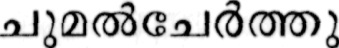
ചുമല്‍ചേര്‍ത്തു
